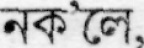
নক'লে,
